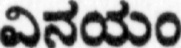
ವಿನಯಂ
